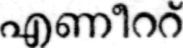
എണീററ്
